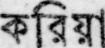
করিয়া
